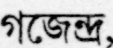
গজেন্দ্র,
